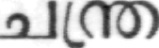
ചന്ത്ര
